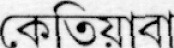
কেতিয়াবা
